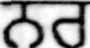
ਨਰ
